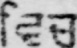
ਵਿਚ
